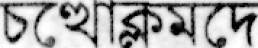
চত্থোক্লমদে
